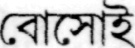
বোসোই
